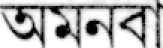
অমনবা
